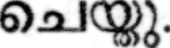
ചെയ്തു.
